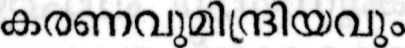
കരണവുമിന്ദ്രിയവും
